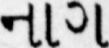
નાગ
